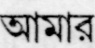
আমার
